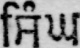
ਸਿੰਘ
